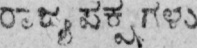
ರಾಜ್ಯಪಕ್ಷಗಳು
